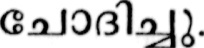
ചോദിച്ചു.
